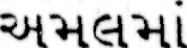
અમલમાં
